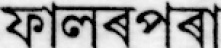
ফালৰপৰা
